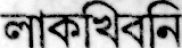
লাকখিবনি
